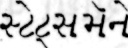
સ્ટેટ્સમૅને
